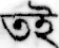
তই
